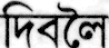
দিবলৈ
